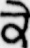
ਕੇ
